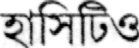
হাসিটিও
